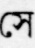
সে
